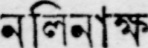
নলিনাক্ষ
